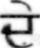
ਦੇ
